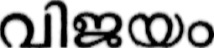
വിജയം
